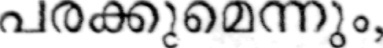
പരക്കുമെന്നും,
